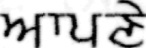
ਆਪਣੇ
